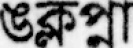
ঙক্লপ্না
